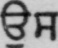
ਉਸ
